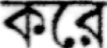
করে
